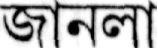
জানলা
